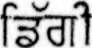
ਡਿੱਂਗੀ
